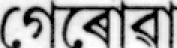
গেৰোৱা
